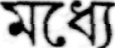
মধ্যে
